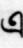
এ
